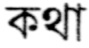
কথা
